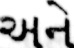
અને
